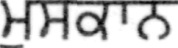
ਮੁਸਕਾਨ
